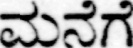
ಮನೆಗೆ
